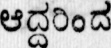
ಆದ್ದರಿಂದ
